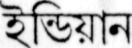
ইন্ডিয়ান
